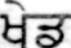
ਖੇਡ
